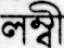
লম্বী
